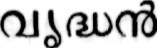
വൃദ്ധന്‍
